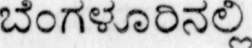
ಬೆಂಗಳೂರಿನಲ್ಲಿ
